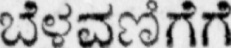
ಬೆಳವಣಿಗೆಗೆ
